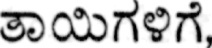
ತಾಯಿಗಳಿಗೆ,
